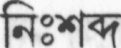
নিঃশব্দ
